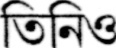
তিনিও
